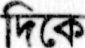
দিকে
